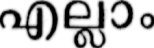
എല്ലാം
